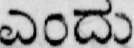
ಎಂದು
